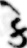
કે
